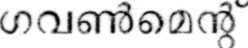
ഗവണ്‍മെന്റ്
